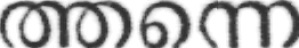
ത്തന്നെ
